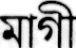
মাগী
